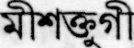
মীশক্তুগী
